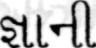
જ્ઞાની
